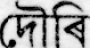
দৌৰি
